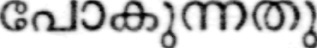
പോകുന്നതു
